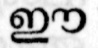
ഈ
